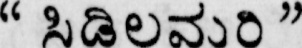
“ಸಿಡಿಲಮರಿ”
